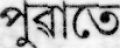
পুৱাতে
